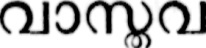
വാസ്തവ
